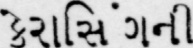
કેરોસિંગની
